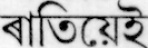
ৰাতিয়েই
